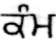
ਕੰਮ
